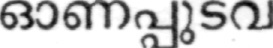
ഓണപ്പുടവ
